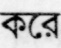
করে
